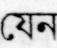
যেন
